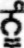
ਨੂੰ
